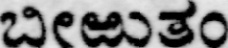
ಬೀಱುತಂ
